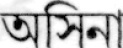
অসিনা
